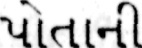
પોતાની
